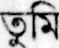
তুমি
